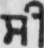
ਸੀ
